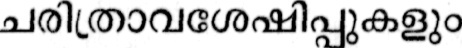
ചരിത്രാവശേഷിപ്പുകളും
